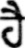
ਹੈ
